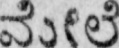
ಮೇಲೆ
